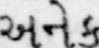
અનેક
